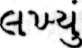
લખ્યું
